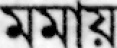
মমায়
